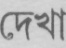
দেখা
